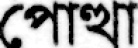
পোত্থা
